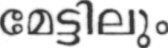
മേട്ടിലും
